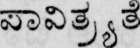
ಪಾವಿತ್ರ್ಯತೆ
